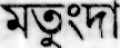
মতুংদা
